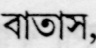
বাতাস,
